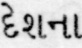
દેશના
